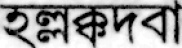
হল্লক্কদবা
